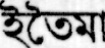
ইতৈমা
